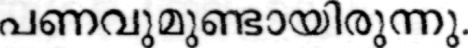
പണവുമുണ്ടായിരുന്നു.
